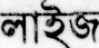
লাইজ
